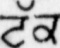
ਟੱਕ
